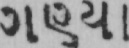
ગણ્યા
